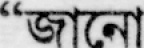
"জানো
